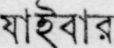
যাইবার
